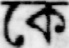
কে
